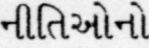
નીતિઓનો
